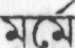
মর্মে
